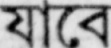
যাবে
